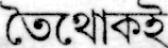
তৈথোকই
